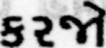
કરજો
